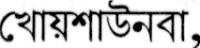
খোয়শাউনবা,
